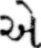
એ
